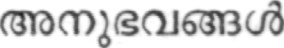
അനുഭവങ്ങള്‍
